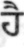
ਹੈ
